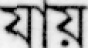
যায়
